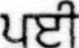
ਪਈ
